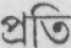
প্ৰতি
